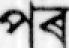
পৰ
